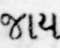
જાય
